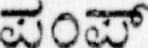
ಪಂಪ್
